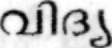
വിദ്യ
